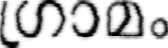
ഗ്രാമം
